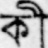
কী
